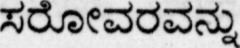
ಸರೋವರವನ್ನು
